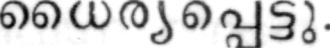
ധൈര്യപ്പെട്ടു.
